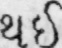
થઈ
